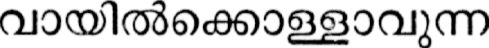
വായില്‍ക്കൊള്ളാവുന്ന
